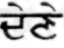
ਦੇਣੇ
